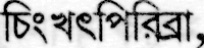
চিংখৎপিরিব্রা,
